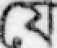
যে
